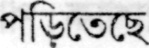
পড়িতেছে
